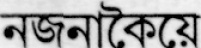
নজনাকৈয়ে
